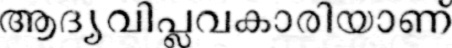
ആദ്യവിപ്ലവകാരിയാണ്
